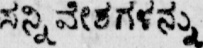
ಸನ್ನಿವೇಶಗಳನ್ನು
